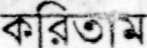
করিতাম
